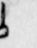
શું
